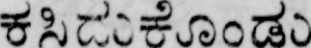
ಕಸಿದುಕೊಂಡು
